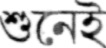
শুনেই
